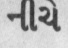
નીચે
